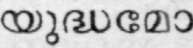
യുദ്ധമോ
